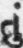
તું
